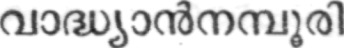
വാദ്ധ്യാന്‍നമ്പൂരി
